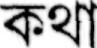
কথা
